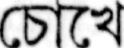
চোখে
